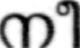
നീ
